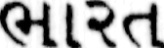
ભારત
